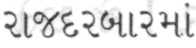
રાજદરબારમાં
